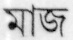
মাজ
